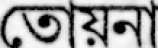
তোয়না
